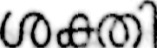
ശക്തി
